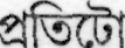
প্রতিটো
